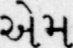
એમ
